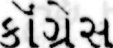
કૉંગ્રેસ
